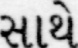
સાથે
